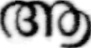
ആ
